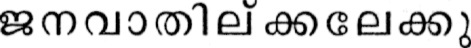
ജനവാതില്ക്കലേക്കു
